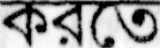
করতে
